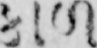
કાળ
